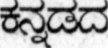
ಕನ್ನಡದ
